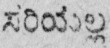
ಸರಿಯಲ್ಲ
